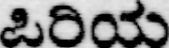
ಪಿರಿಯ
